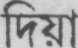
দিয়া
